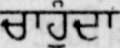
ਚਾਹੁੰਦਾ
